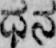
ಧನ
